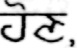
ਹੋਣ,
